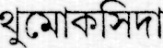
থুমোকসিদা
